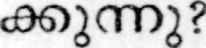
ക്കുന്നു?
